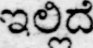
ಇಲ್ಲಿದೆ
